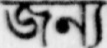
জন্য
